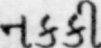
નક્કી
